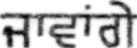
ਜਾਵਾਂਗੇ
